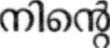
നിന്റെ
